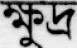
ক্ষুদ্র
